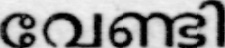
വേണ്ടി
